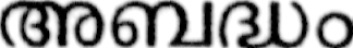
അബദ്ധം
